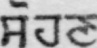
ਸੋਹਣ
